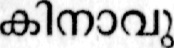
കിനാവു
